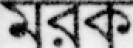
মরক
